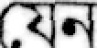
যেন
